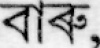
বাৰু,
